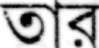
তার
